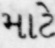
માટે
